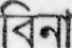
বিনা
